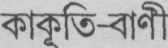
কাকূতি-বাণী
